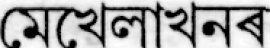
মেখেলাখনৰ
